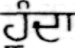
ਹੁੰਦਾ
